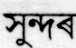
সুন্দৰ
